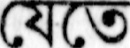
যেতে
